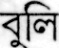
বুলি
